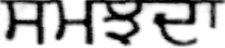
ਸਮਝਦਾ
